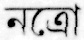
নত্রো
